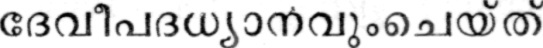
ദേവീപദധ്യാനവുംചെയ്ത്
